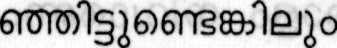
ഞ്ഞിട്ടുണ്ടെങ്കിലും
